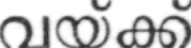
വയ്ക്ക്
